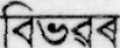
বিভৱৰ
